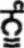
ਨੂੰ
